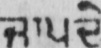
ਜਾਪਦੇ
